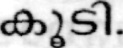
കൂടി.
